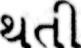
થતી
